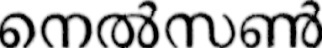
നെല്‍സണ്‍
